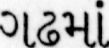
ગઢમાં
